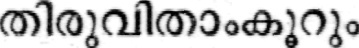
തിരുവിതാംകൂറും
